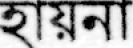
হায়না
